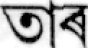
তাৰ
